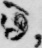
છે,
